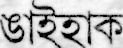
ঙাইহাক
